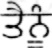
ਤੈਨੂੰ
